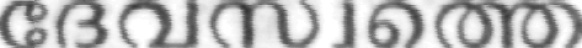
ദേവസ്വത്തെ
